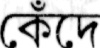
কেঁদে
